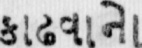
કાઢવાનો
